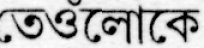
তেওঁলোকে
